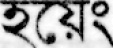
হয়েং
